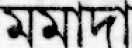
মমাদা
